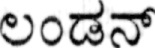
ಲಂಡನ್
